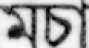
মচা
